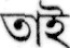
তাই
